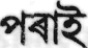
পৰাই
